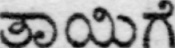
ತಾಯಿಗೆ
